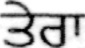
ਤੇਰਾ
